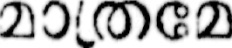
മാത്രമേ
